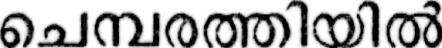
ചെമ്പരത്തിയില്‍
